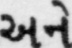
અને
